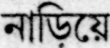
নাড়িয়ে
